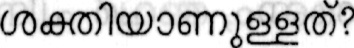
ശക്തിയാണുള്ളത്?
